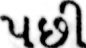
પછી
